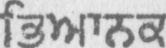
ਭਿਆਨਕ
